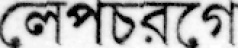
লেপচরগে
